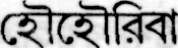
হৌহৌরিবা
